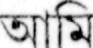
আমি
